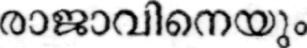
രാജാവിനെയും
